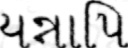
યન્નાપિ
